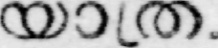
യാത്ര.
